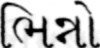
ભિન્નો
